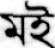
মই
